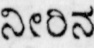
ನೀರಿನ
